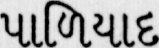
પાળિયાદ
